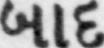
બાદ
